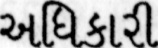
અધિકારી
